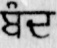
ਬੰਦ
